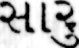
સારુ
